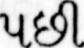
પછી
